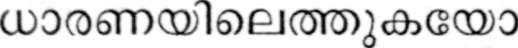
ധാരണയിലെത്തുകയോ
